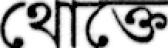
থোক্তে
